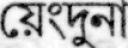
য়েংদুনা
